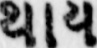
થાય
